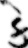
કે
